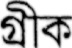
গ্রীক
